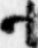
ન
